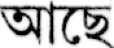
আছে
